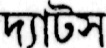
দ্যাটস
